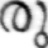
രു
